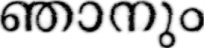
ഞാനും
